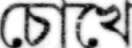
চোখে
